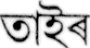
তাইৰ
